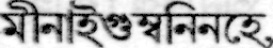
মীনাইগুম্বনিনহে,
